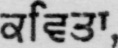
ਕਵਿਤਾ,
